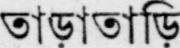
তাড়াতাড়ি
